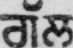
ਗੱਲ
